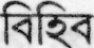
বিহিব
